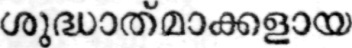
ശുദ്ധാത്മാക്കളായ
